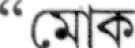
"মোক
